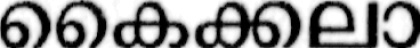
കൈക്കലാ
